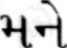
મને
